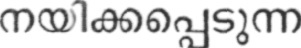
നയിക്കപ്പെടുന്ന
